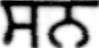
ਸਨ
